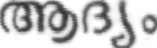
ആദ്യം
